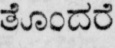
ತೊಂದರೆ
